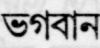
ভগবান
